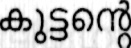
കുട്ടന്റെ
